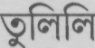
তুলিলি
